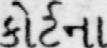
કોર્ટના
